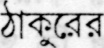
ঠাকুরের
